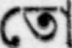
তো
